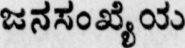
ಜನಸಂಖ್ಯೆಯ
